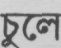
চুলে
